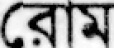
রোম
